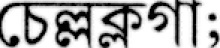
চেল্লক্লগা;
